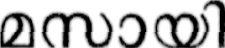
മസായി
